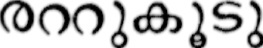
രററുകൂടു
